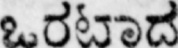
ಒರಟಾದ
